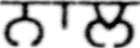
ਨਾਲ
